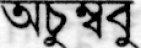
অচুম্ববু
